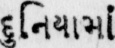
દુનિયામાં
